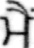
ਮੈਂ
